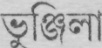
ভুঞ্জিলা
